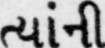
ત્યાંની
